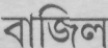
বাজিল
